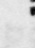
તું
